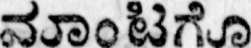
ಮಾಂಟಿಗೊ
